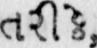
તરીકે,
